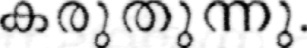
കരുതുന്നു.
